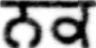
ਨਕ
